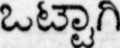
ಒಟ್ಟಾಗಿ
